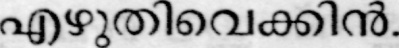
എഴുതിവെക്കിന്‍.
